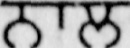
ਨਾਲ
